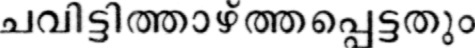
ചവിട്ടിത്താഴ്ത്തപ്പെട്ടതും
